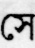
সে
